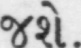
જશે.
